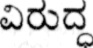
ವಿರುದ್ಧ
